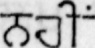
ਨਹੀਂ
